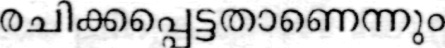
രചിക്കപ്പെട്ടതാണെന്നും
